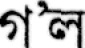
গ'ল
